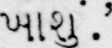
ખાશું.'
